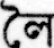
লৈ
